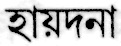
হায়দনা
